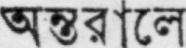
অন্তরালে
